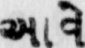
આવે
